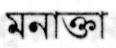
মনাক্তা
